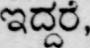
ಇದ್ದರೆ,
